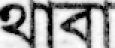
থাবা
